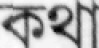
কথা
